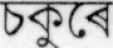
চকুৰে
